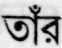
তাঁর
